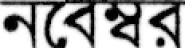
নবেম্বর
